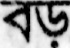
বড়
